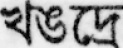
খঙদ্রে
